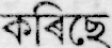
কৰিছে
